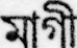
মাগী
